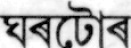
ঘৰটোৰ
